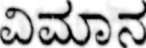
ವಿಮಾನ
